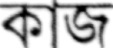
কাজ
